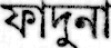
ফাদুনা
